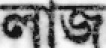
লাজ
